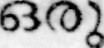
ഒരു
